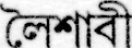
লৈশাবী
